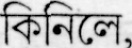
কিনিলে,
